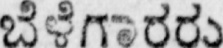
ಬೆಳೆಗಾರರು
